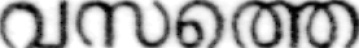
വസത്തെ
